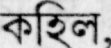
কহিল,
